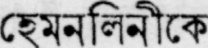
হেমনলিনীকে
